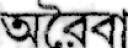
অরৈবা
